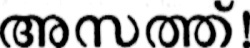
അസത്ത്!
